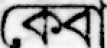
কেবা
